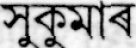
সুকুমাৰ
